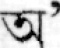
অ'
